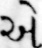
એ
